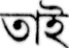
তাই
